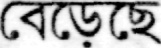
বেড়েছে
